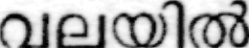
വലയില്‍
